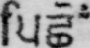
ਪਿਛੋਂ
